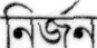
নিৰ্জন
